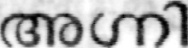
അഗ്നി
